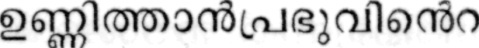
ഉണ്ണിത്താന്‍പ്രഭുവിന്റെ
